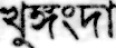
খুঙ্গংদা
